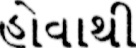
હોવાથી
